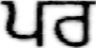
ਪਰ
